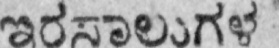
ಇರಸಾಲುಗಳ
